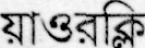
য়াওরক্লি
